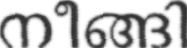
നീങ്ങി
